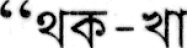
“থক-খা
